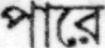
পারে
